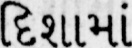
દિશામાં
